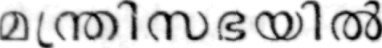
മന്ത്രിസഭയില്‍
